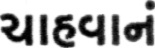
ચાહવાનં
